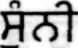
ਸੁੰਨੀ
